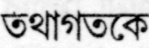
তথাগতকে
